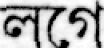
লগে
